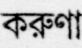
করুণা
